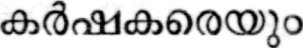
കര്‍ഷകരെയും
